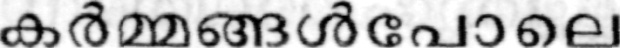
കര്‍മ്മങ്ങള്‍പോലെ
